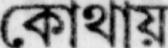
কোথায়
